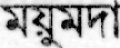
ময়ুমদা
